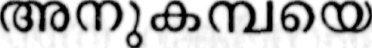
അനുകമ്പയെ
